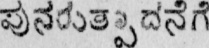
ಪುನರುತ್ಪಾದನೆಗೆ
